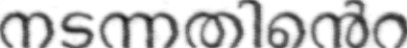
നടന്നതിന്റെ
